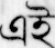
এই
